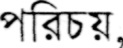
পরিচয়,
